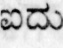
ಐದು
